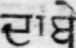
ਦਾਬੇ
